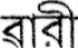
ৱারী
